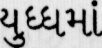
યુધ્ધમાં
